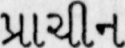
પ્રાચિન
